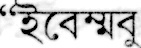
“ইবেম্মা
